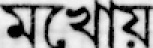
মখোয়
